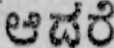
ಆದರೆ
